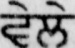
ਵੇਲੇ
